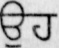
ਉਹ
